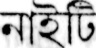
নাইটি
